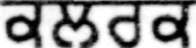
ਕਲਰਕ
